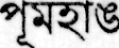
পূমহাঙ
